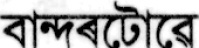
বান্দৰটোৱে
